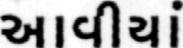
આવીયાં
